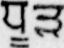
ਧੂੜ
